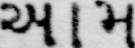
આમ
